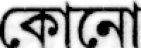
কোনো
